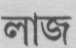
লাজ
